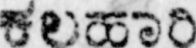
ಕಲಹಾರಿ
